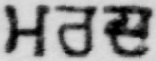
ਮਰਦ
